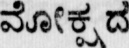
ಮೋಕ್ಷದ
